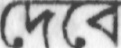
দেবে
